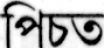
পিচত
